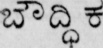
ಬೌದ್ಧಿಕ
